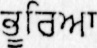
ਭੂਰਿਆ
